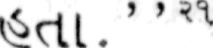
હતા."૨૧
